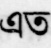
এত
